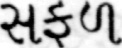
સફળ
